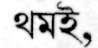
থমই,
